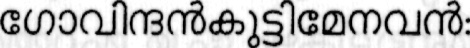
ഗോവിന്ദന്‍കുട്ടിമേനവന്‍:
